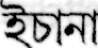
ইচানা
